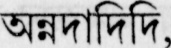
অন্নদাদিদি,
